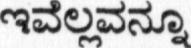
ಇವೆಲ್ಲವನ್ನೂ
